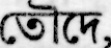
তৌদে,
